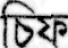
চিফ
